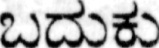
ಬದುಕು
